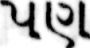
પણ
